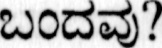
ಬಂದವು?
